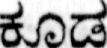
ಕೂಡ
